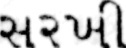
સરખી
